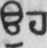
ਉਹ
